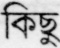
কিছু
